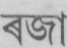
ৰজা
